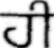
ਹੀ
